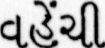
વહેંચી
